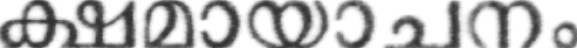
ക്ഷമായാചനം
